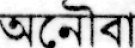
অনৌবা
